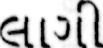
લાગી
